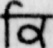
ਕਿ
